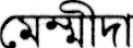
মেম্মীগা
